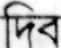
দিব
